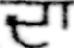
ਦਾ
